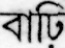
বাঢ়ি
